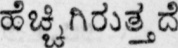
ಹೆಚ್ಚಿಗಿರುತ್ತದೆ
